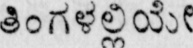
ತಿಂಗಳಲ್ಲಿಯೇ
